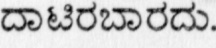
ದಾಟಿರಬಾರದು.
